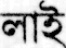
লাই
